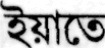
ইয়াতে
